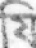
যি
